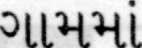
ગામમાં
